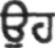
ਉਹ
